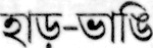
হাড়-ভাঙি
